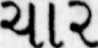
ચાર
